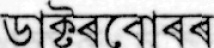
ডাক্টৰবোৰৰ
